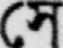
সে
